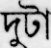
দুটা
